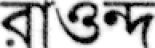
রাওন্দ
